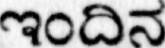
ಇಂದಿನ
